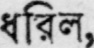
ধরিল,
